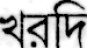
খরদি
